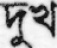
দুখ
